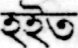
হইত
